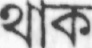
থাক
